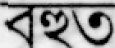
বহুত
